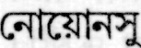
নোয়োনসু
